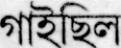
গাইছিল
